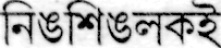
নিঙশিঙলকই
